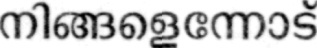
നിങ്ങളെന്നോട്
